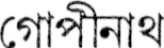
গোপীনাথ
